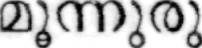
മൂന്നുരു
